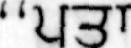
''ਪਤਾ
